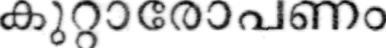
കുറ്റാരോപണം
